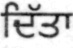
ਦਿੱਤਾ
